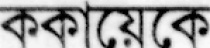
ককায়েকে
